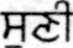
ਸੁਣੀ
